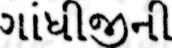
ગાંધીજીની
